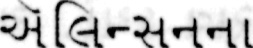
એલિન્સનના
